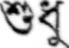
শুধু
